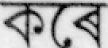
কৰে
